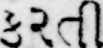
કરતી
